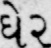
ઘેર
